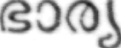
ഭാര്യ
